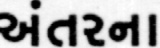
અંતરના
